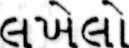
લખેલો
